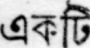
একটি
